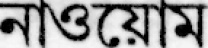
নাওয়োম
